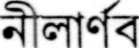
নীলার্ণব
